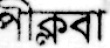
পীক্লবা
